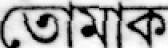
তোমাক
